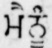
ਮੈਨੂੰ
